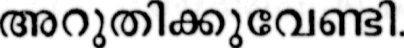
അറുതിക്കുവേണ്ടി.
